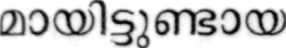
മായിട്ടുണ്ടായ
